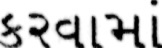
કરવામાં
